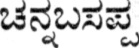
ಚನ್ನಬಸಪ್ಪ
